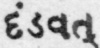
દંડવત્
